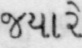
જ્યારે
